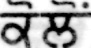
ਕੋਲੋਂ
